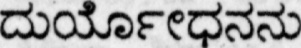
ದುರ್ಯೋಧನನು
